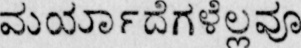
ಮರ್ಯಾದೆಗಳೆಲ್ಲವೂ
